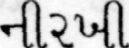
નીરખી
